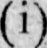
(i)
